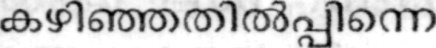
കഴിഞ്ഞതില്‍പ്പിന്നെ
